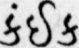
કંઈક
